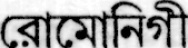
রোমোনিগী
